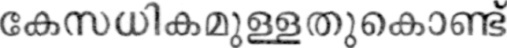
കേസധികമുള്ളതുകൊണ്ട്
